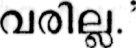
വരില്ല.’
